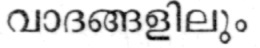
വാദങ്ങളിലും
